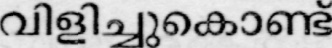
വിളിച്ചുകൊണ്ട്
